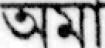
অমা
